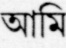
আমি
